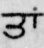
ਤਾਂ
